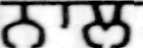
ਨਾਲ
